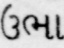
ઉભા
